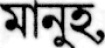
মানুহ,
